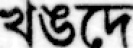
খঙদে
